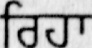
ਰਿਹਾ
